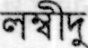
লম্বীদু
